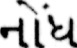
નોંધ
